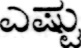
ಎಷ್ಟು
